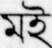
মই
